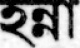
হন্না
